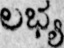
ಲಭ್ಯ
